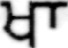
ਖਾ
